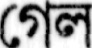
গেল
